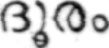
ദൂരം
